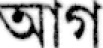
আগ
